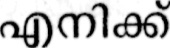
എനിക്ക്
